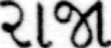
રાજા
